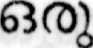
ഒരു
